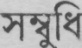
সম্বুধি
